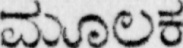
ಮೂಲಕ
